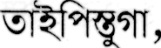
তাইপিস্তুগা,
